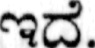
ಇದೆ.
